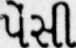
પેંસી
